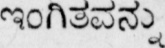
ಇಂಗಿತವನ್ನು
